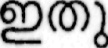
ഇതു
